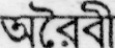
অরৈবী
